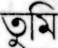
তুমি
